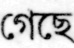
গেছে
